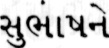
સુભાષને
